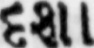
દશા
